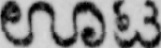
ಊಟ
